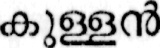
കുള്ളന്‍
